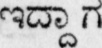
ಇದ್ದಾಗ
